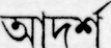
আদর্শ
